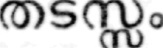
തടസ്സം
